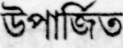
উপার্জিত
